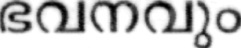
ഭവനവും
